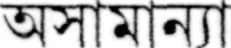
অসামান্যা
